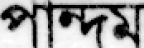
পান্দম
